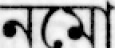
নমো
